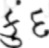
કુંદ
